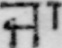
ਜਾ
